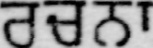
ਰਚਨਾ
